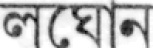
লঘোন
